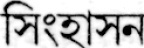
সিংহাসন
